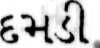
દમડી
